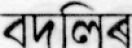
বদলিৰ
